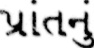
પ્રાંતનું
